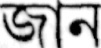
জান
